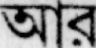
আর
